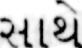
સાથે
